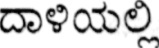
ದಾಳಿಯಲ್ಲಿ
